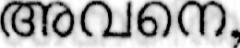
അവനെ,
